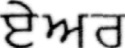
ਏਅਰ
